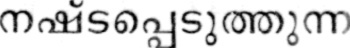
നഷ്ടപ്പെടുത്തുന്ന
